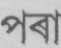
পৰা
